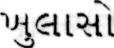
ખુલાસો
